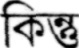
কিন্তু
